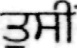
ਤੁਸੀਂ
